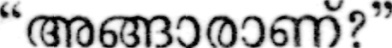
“അങ്ങാരാണ്?”
